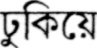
ঢুকিয়ে
